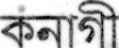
কনাগী
